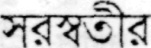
সরস্বতীর
